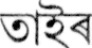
তাইৰ
